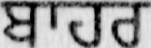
ਬਾਹਰ
